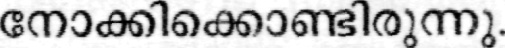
നോക്കിക്കൊണ്ടിരുന്നു.
